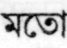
মতো
